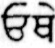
ਓਥੇ
